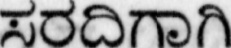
ಸರದಿಗಾಗಿ
